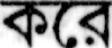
করে
